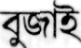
বুজাই
